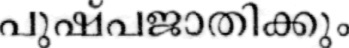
പുഷ്പജാതിക്കും
